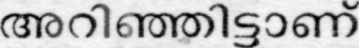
അറിഞ്ഞിട്ടാണ്
